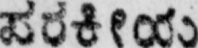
ಪರಕೀಯ
